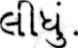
લીધું.
